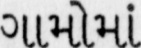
ગામોમાં
